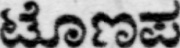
ಟೊಣಪ
